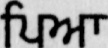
ਪਿਆ
